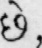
છે,
